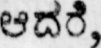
ಆದರೆ,
